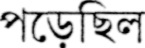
পড়েছিল
